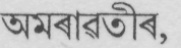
অমৰাৱতীৰ,
